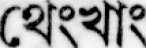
থেংখাং
